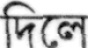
দিলে
